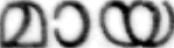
മായ
